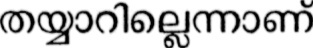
തയ്യാറില്ലെന്നാണ്
